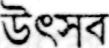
উৎসব
